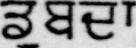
ਡੁਬਦਾ
